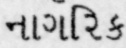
નાગરિક
